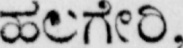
ಹಲಗೇರಿ,
